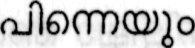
പിന്നെയും
